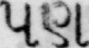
પણ
